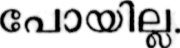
പോയില്ല.
